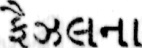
ફૈઝલના
